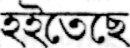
হইতেছে
